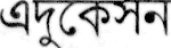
এদুকেসন
